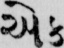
એક
